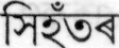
সিহঁতৰ
